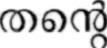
തന്റെ
